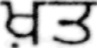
ਖ਼ਤ
